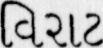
વિરાટ
